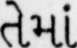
તેમાં
